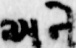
અને
